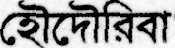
হৌদৌরিবা
